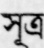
সূত্র
